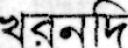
খরনদি
